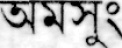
অমসুং
